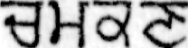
ਚਮਕਣ
